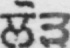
ਲੋੜ
